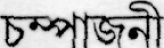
চম্পাজনী
